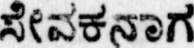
ಸೇವಕನಾಗ
